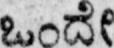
ಒಂದೇ
